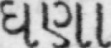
ઘણા
